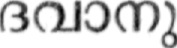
ദവാനു
